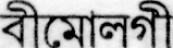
বীমোলগী
